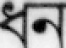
ধন
